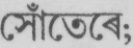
সোঁতেৰে;
